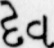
દેવ
